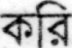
করি
